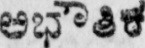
ಅಭೌತಿಕ
